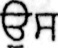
ਉਸ
